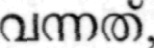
വന്നത്,
